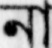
না
